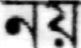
নয়
